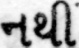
નથી
